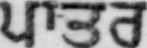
ਪਾਤਰ
